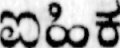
ಐಹಿಕ
